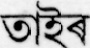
তাইৰ
